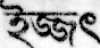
ইজ্জৎ
